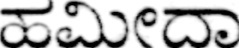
ಹಮೀದಾ
